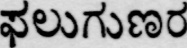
ಫಲುಗುಣರ
